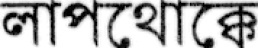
লাপথোক্কে
